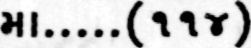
મા.....(૧૧૪)
